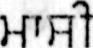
ਮਾਸੀ
